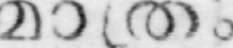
മാത്രം
